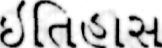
ઇતિહાસ
